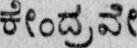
ಕೇಂದ್ರವೇ
